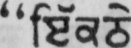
''ਇੱਕਠੇ
